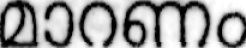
മാറണം
